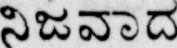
ನಿಜವಾದ
